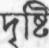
দৃষ্টি
